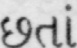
છતાં
